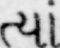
ત્યાં
